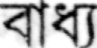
বাধ্য
